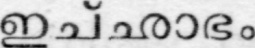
ഇച്ഛാഭം
